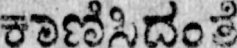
ಕಾಣಿಸಿದಂತೆ
